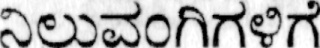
ನಿಲುವಂಗಿಗಳಿಗೆ
